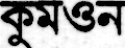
কুমওন
